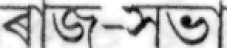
ৰাজ-সভা
